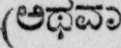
(ಅಥವಾ
